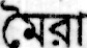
মৈরা
